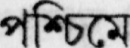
পশ্চিমে
